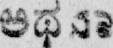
ಅಥವಾ
